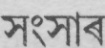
সংসাৰ
